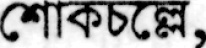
শোকচল্লে,
